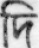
দি
